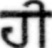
ਹੀ
